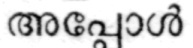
അപ്പോള്‍
